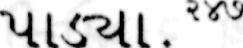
પાડ્યા.૨૪૭
